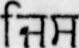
ਜਿਸ
